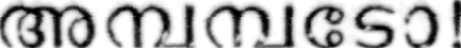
അമ്പമ്പടോ!
